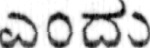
ಎಂದು
